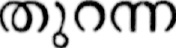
തുറന്ന
